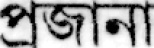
প্রজানা
